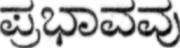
ಪ್ರಭಾವವು
